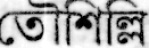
তৌশিল্লি
